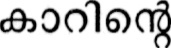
കാറിന്റെ
